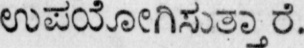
ಉಪಯೋಗಿಸುತ್ತಾರೆ.
